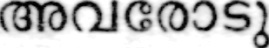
അവരോടു
